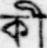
কী
